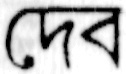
দেব
